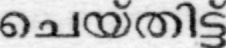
ചെയ്തിട്ട്
